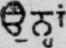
ਉਨ੍ਹਾਂ
